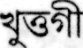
খুত্তগী
